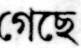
গেছে
